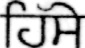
ਹਿੱਸੇ
